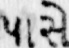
પાસે
